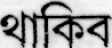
থাকিব
